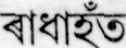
ৰাধাহঁত
